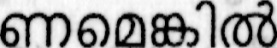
ണമെങ്കില്‍
